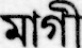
মাগী
